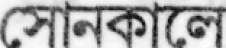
সোনকালে
